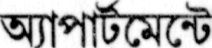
অ্যাপার্টমেন্টে
